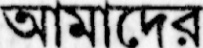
আমাদের
